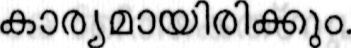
കാര്യമായിരിക്കും.
